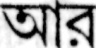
আর
